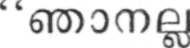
"ഞാനല്ല
